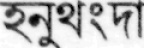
হনুথংদা
